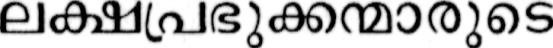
ലക്ഷപ്രഭുക്കന്മാരുടെ
